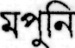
মপুনি
